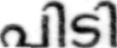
പിടി
